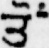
ਤੋਂ
